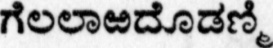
ಗೆಲಲಾಱದೊಡಣ್ಮಿ
